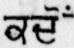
ਕਦੋਂ
